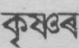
কৃষ্ণৰ
